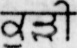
ਕੁੜੀ
